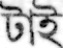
টাই
